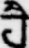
ਹੈ
